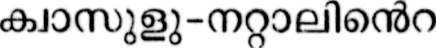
ക്വാസുളു-നറ്റാലിന്റെ
